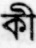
কী
